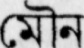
মৌন
